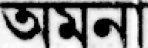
অমনা
